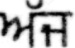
ਅੱਜ
